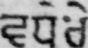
ਵਧੇਰੇ
